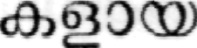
കളായ
